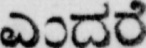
ಎಂದರೆ
